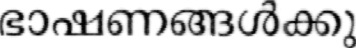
ഭാഷണങ്ങള്‍ക്കു
